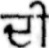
ਦੀ
